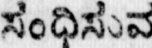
ಸಂಧಿಸುವ
